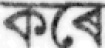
কৰে
